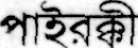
পাইরক্কী
